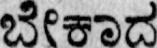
ಬೇಕಾದ
